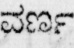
ವರ್ಣ
